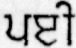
ਪਈ
